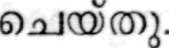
ചെയ്തു.
